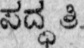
ಪದ್ಧತಿ
